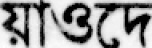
য়াওদে
